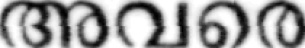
അവരെ
